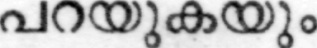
പറയുകയും
